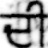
ਦੀ
